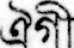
ঐগী
